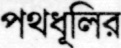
পথধূলির
